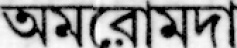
অমরোমদা
